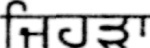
ਜਿਹੜਾ
